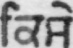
ਕਿਸੇ
